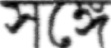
সঙ্গে
